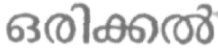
ഒരിക്കല്‍
